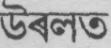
উৰলত
